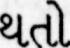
થતો
